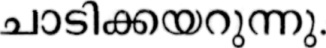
ചാടിക്കയറുന്നു.
